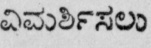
ವಿಮರ್ಶಿಸಲು
